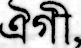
ঐগী,
